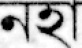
নহা
